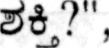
ಶಕ್ತಿ?”,
